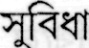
সুবিধা
